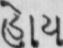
હોય
